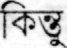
কিন্তু
